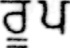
ਰੂਪ
